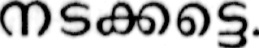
നടക്കട്ടെ.
